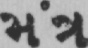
મંત્ર
